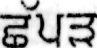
ਛੱਪੜ
